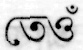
তেওঁ
